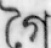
গৈ
